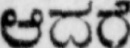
ಆದರೆ
